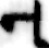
ન
